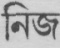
নিজ
